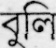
বুলি
